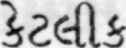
કેટલીક
